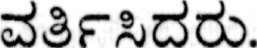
ವರ್ತಿಸಿದರು.
